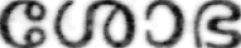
ശോഭ
